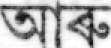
আৰু
